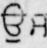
ਉਸ
